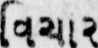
વિચાર
